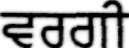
ਵਰਗੀ
